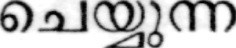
ചെയ്യുന്ന
